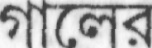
গালের
